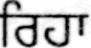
ਰਿਹਾ
